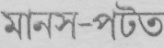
মানস-পটত
